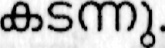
കടന്നു.
